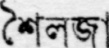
শৈলজা
